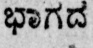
ಭಾಗದ
